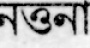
নত্তনা
